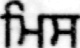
ਮਿਸ
